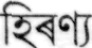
হিৰণ্য
